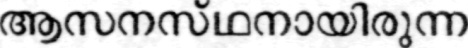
ആസനസ്ഥനായിരുന്ന
